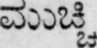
ಮುಚ್ಚಿ
